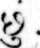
છું.
